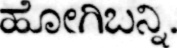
ಹೋಗಿಬನ್ನಿ.
